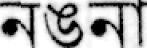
নঙনা
